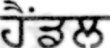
ਹੈਂਡਲ
